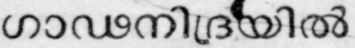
ഗാഢനിദ്രയില്‍
